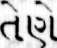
તેણે
